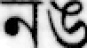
নঙ
